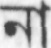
না
